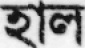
হাল
